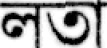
লতা
